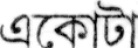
একোটা
